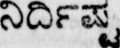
ನಿರ್ದಿಷ್ಟ
